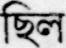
ছিল
